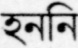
হননি
